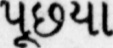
પૂછયા
